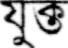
যুক্ত
